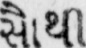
સૌથી
